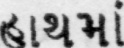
હાથમાં
